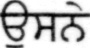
ਉਸਨੇ
